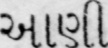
આણી
